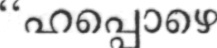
"ഹപ്പൊഴെ
